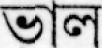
ভাল
